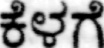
ಕೆಳಗೆ
